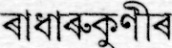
ৰাধাৰুকুণীৰ
